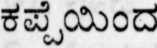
ಕಪ್ಪೆಯಿಂದ
